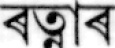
ৰত্নাৰ
